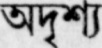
অদৃশ্য
